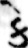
કે
